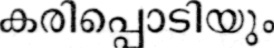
കരിപ്പൊടിയും
